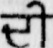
ਦੀ
